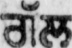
ਗੱਲ
